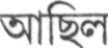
আছিল
